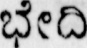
ಭೇದಿ
